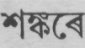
শঙ্কৰে
